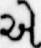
એ
